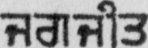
ਜਗਜੀਤ
